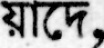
য়াদে,
